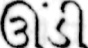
ઊંડી
